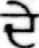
ਦੇ
